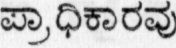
ಪ್ರಾಧಿಕಾರವು
